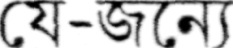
যে-জন্যে
